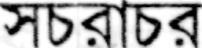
সচরাচর
